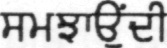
ਸਮਝਾਉਂਦੀ
